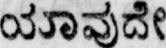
ಯಾವುದೇ
